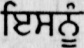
ਇਸਨੂੰ
